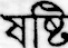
ষষ্টি
